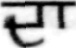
ਦਾ
